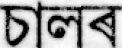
চালৰ
